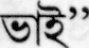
ভাই"
